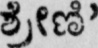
ಶ್ರೇಣಿ'
